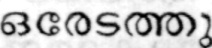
ഒരേടത്തു
